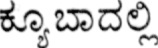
ಕ್ಯೂಬಾದಲ್ಲಿ
